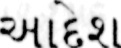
આદેશ
